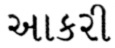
આકરી
